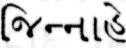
જિન્નાહે
